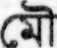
মৌ
